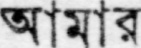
আমার
